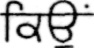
ਕਿਉਂ
